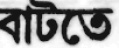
বাটতে
